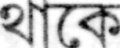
থাকে
